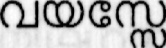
വയസ്സേ
